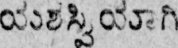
ಯಶಸ್ವಿಯಾಗಿ
